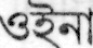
ওইনা
